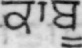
ਕਾਬੂ
